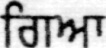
ਗਿਆ
